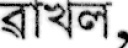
ৱাখল,
